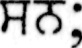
ਸਨ;
